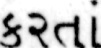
કરતાં
